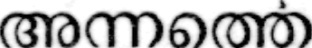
അന്നത്തെ
